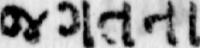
જગતના
